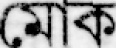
মোক
